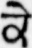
ਕੇ
